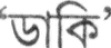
'ডাকি'
